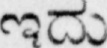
ಇದು
